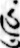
હું
